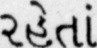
રહેતાં
